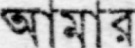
আমার
